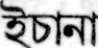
ইচানা
